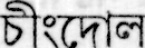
চীংদোল
